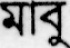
মাবু
